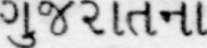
ગુજરાતના
